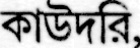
কাউদরি,
